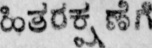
ಹಿತರಕ್ಷಣೆಗೆ
